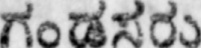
ಗಂಡಸರು
